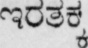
ಇರತಕ್ಕ
